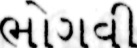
ભોગવી
